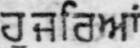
ਹੁਜਰਿਆਂ
